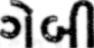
ગેબી
